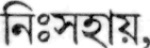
নিঃসহায়,
